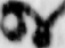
જ
